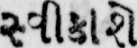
સ્વીકાશે
